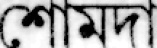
শোমদা
